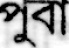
পুবা
